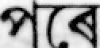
পৰে
